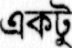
একটু
